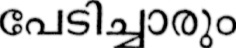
പേടിച്ചാരും
